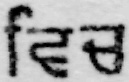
ਵਿਚ
